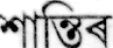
শান্তিৰ
